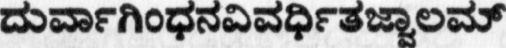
ದುರ್ವಾಗಿ೦ಧನವಿವರ್ಧಿತಜ್ವಾಲಮ್
